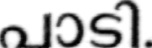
പാടി.
